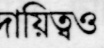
দায়িত্বও
